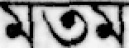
মতম
